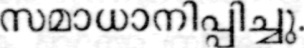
സമാധാനിപ്പിച്ചു.
